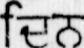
ਦਿਨ
